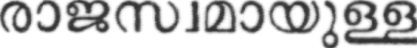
രാജസ്വമായുള്ള
